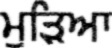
ਮੁੜਿਆ
